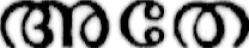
അതേ
